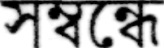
সম্বন্ধে
